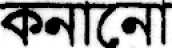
কনানো
